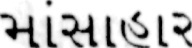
માંસાહાર
